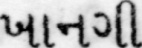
ખાનગી
